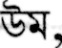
উম,
